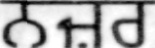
ਨਜ਼ਰ
